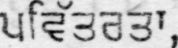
ਪਵਿੱਤਰਤਾ,
